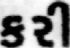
કરી
